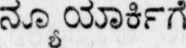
ನ್ಯೂಯಾರ್ಕಿಗೆ
